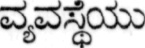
ವ್ಯವಸ್ಥೆಯು
